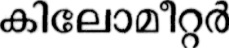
കിലോമീറ്റര്‍
